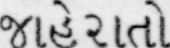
જાહેરાતો
